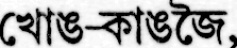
খোঙ-কাঙজৈ,
